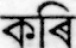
কৰি
